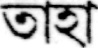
তাহা
